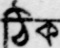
ঠিক
